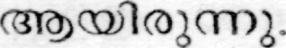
ആയിരുന്നു.
